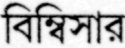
বিম্বিসার
